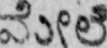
ಮೇಲೆ
